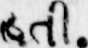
હતી.
